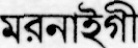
মরনাইগী
